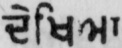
ਦੇਖਿਆ
